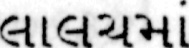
લાલચમાં
